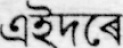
এইদৰে
